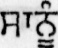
ਸਾਨੂੰ
